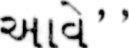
આવે"
